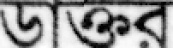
ডাক্তর
